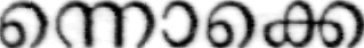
ന്നൊക്കെ
